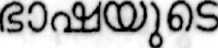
ഭാഷയുടെ
